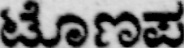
ಟೊಣಪ
